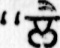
''ਲੈ
